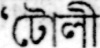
‘টোলী
